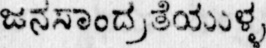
ಜನಸಾಂದ್ರತೆಯುಳ್ಳ
